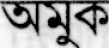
অমুক
